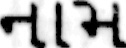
નામ
